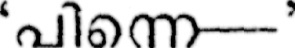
‘പിന്നെ-’
